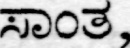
ಸಾಂತ,
